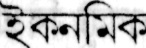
ইকনমিক
